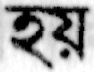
হয়
